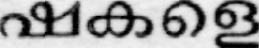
ഷകളെ
